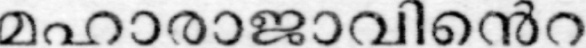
മഹാരാജാവിന്റെ
